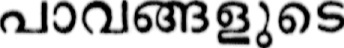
പാവങ്ങളുടെ
